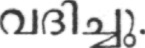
വദിച്ചു.
